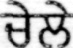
ਚੇਲੇ
